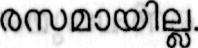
രസമായില്ല.
